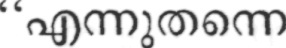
"എന്നുതന്നെ
